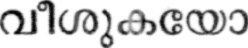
വീശുകയോ
